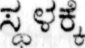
ಸ್ಥಳಕ್ಕೆ
